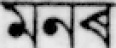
মনৰ
